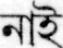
নাই
